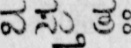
ವಸ್ತುತಃ
